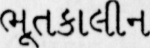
ભૂતકાલીન
